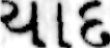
યાદ
